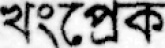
খংপ্রেক
